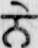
ਨੇ
